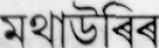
মথাউৰিৰ
